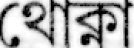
থোক্না
